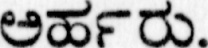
ಅರ್ಹರು.
